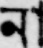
না
